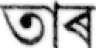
তাৰ
